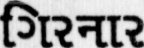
ગિરનાર
